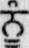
ਨੂੰ
